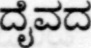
ದೈವದ
